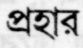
প্রহার
